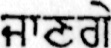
ਜਾਣਗੇ
